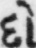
દો
